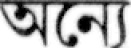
অন্যে
